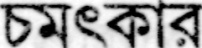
চমৎকার
